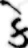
કે
